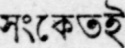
সংকেতই
